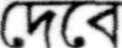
দেবে
